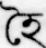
হৈ
